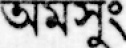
অমসুং
